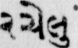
રચેલું
